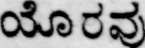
ಯೊರವು
